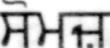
ਸੋਮਜ਼
